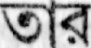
তার
